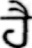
ਹੈ
